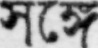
সঙ্গে
